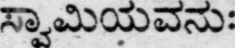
ಸ್ವಾಮಿಯವನು:
